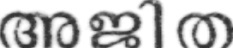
അജിത
